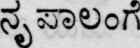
ನೃಪಾಲಂಗೆ
